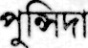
পুন্সিদা
